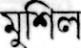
মুশিল
